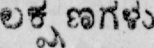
ಲಕ್ಷಣಗಳು
